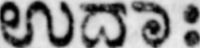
ಉದಾಃ
